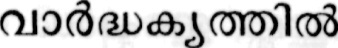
വാര്‍ദ്ധക്യത്തില്‍
